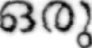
ഒരു
